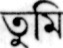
তুমি
